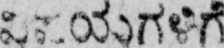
ವಿಷಯಗಳಿಗೆ
